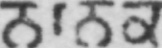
ਨਾਨਕ
